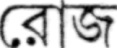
রোজ
